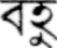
বহু
